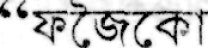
“ফজৈকো
